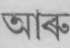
আৰু
